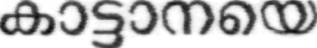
കാട്ടാനയെ
